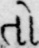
તો
